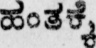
ಹಂತಕ್ಕೆ
